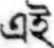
এই
